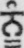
ਨੂੰ
